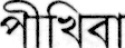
পীখিবা
